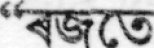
"ৰজতে
